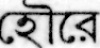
হৌরে
